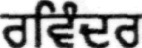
ਰਵਿੰਦਰ
